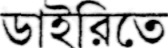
ডাইরিতে
